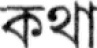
কথা
